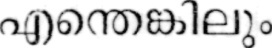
എന്തെങ്കിലും
